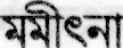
মমীৎনা
